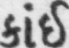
કાંઈ
